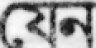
যেন
